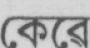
কেৱে
